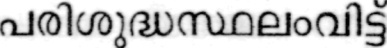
പരിശുദ്ധസ്ഥലംവിട്ട്
